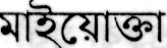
মাইয়োক্তা
